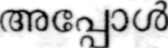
അപ്പോള്‍
